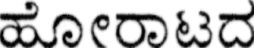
ಹೋರಾಟದ
